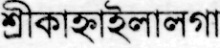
শ্রীকাহ্নাইলালগা
